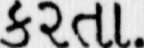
કરતા.
